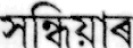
সন্ধিয়াৰ
